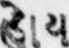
હોય
